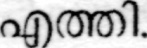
എത്തി.
